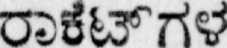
ರಾಕೆಟ್‌ಗಳ
